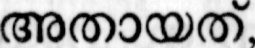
അതായത്,
